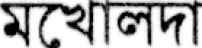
মখোলদা
